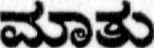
ಮಾತು
